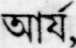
আর্য,
